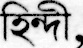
হিন্দী,
